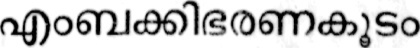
എംബക്കിഭരണകൂടം
